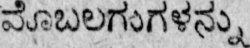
ಮೊಬಲಗುಗಳನ್ನು
